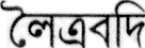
লৈত্রবদি
